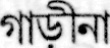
গাড়ীনা
